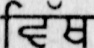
ਵਿੱਥ
